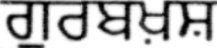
ਗੁਰਬਖ਼ਸ਼
